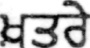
ਖ਼ਤਰੇ
